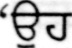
'ਉਹ
